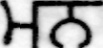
ਮਨ
